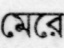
মেরে
